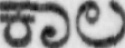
ಕಾಲ
